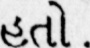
હતો.
